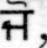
ਜੋ,
